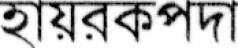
হায়রকপদা
